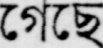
গেছে
